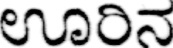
ಊರಿನ
